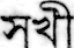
সখী
